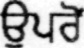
ਉਪਰੋਂ
